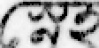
স্নেহ
